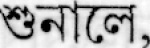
শুনালে,
